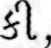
કી,
